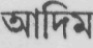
আদিম
